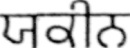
ਯਕੀਨ
